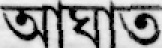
আঘাত
